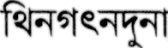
থিনগৎনদুনা
